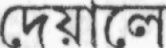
দেয়ালে
